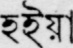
হইয়া
